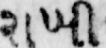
રાખી
